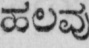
ಹಲವು
